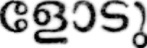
ളോടു
